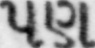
પણ
